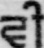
ਵੀ
